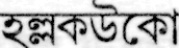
হল্লকউকো
